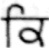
ਕਿ
